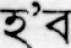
হ'ব
